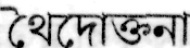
থৈদোক্তনা
